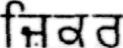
ਜ਼ਿਕਰ
